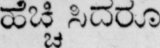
ಹೆಚ್ಚಿಸಿದರೂ
